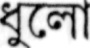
ধুলো
